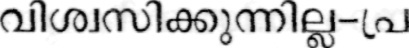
വിശ്വസിക്കുന്നില്ല-പ്ര
